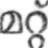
മറ്റ്
